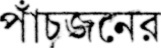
পাঁচজনের
